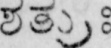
ಶತ್ರುಃ
